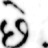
છે.
